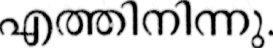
എത്തിനിന്നു.
